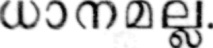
ധാനമല്ല.
